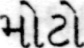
મોટો
